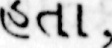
હતા,
